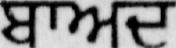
ਬਾਅਦ
